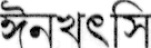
ঈনখৎসি
